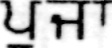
ਪੁਜਾ
